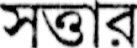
সত্তার
